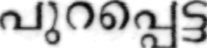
പുറപ്പെട്ട
